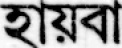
হায়বা
